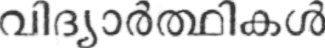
വിദ്യാര്‍ത്ഥികള്‍
